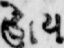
હોય
